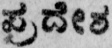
ಪ್ರದೇಶ
